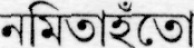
নমিতাহঁতো
